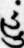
હું
